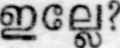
ഇല്ലേ?
